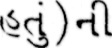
હતું)ની
